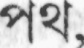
পথ,
